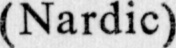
(Nardic)
